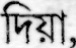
দিয়া,
